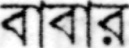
বাবার
